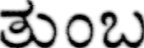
ತುಂಬ
